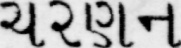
ચરણન
